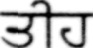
ਤੀਹ
